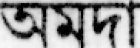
অমদা
